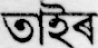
তাইৰ
